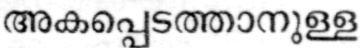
അകപ്പെടത്താനുള്ള
